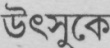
উৎসুকে
